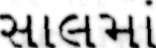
સાલમાં
